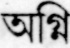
অগ্নি
